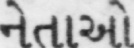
નેતાઓ
